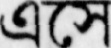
এসে
